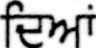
ਦਿਆਂ
